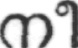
നീ
